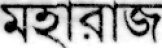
মহারাজ
